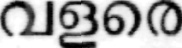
വളരെ
